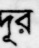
দূর
